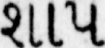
શાપ
